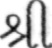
શ્રી
